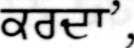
ਕਰਦਾ',
